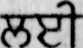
ਲਈ
